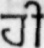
ਹੀ
